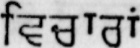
ਵਿਚਾਰਾਂ
